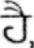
ਹੈ,
